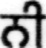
ਨੀ
